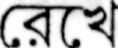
রেখে
